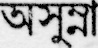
অসুম্না
